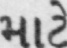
માટે
